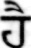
ਹੈ
